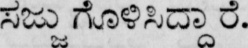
ಸಜ್ಜುಗೊಳಿಸಿದ್ದಾರೆ.
